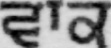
ਵਾਕ
